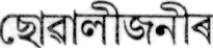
ছোৱালীজনীৰ
